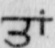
ਤਾਂ
